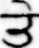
ਤੇ
